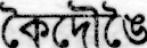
কৈদৌঙৈ
